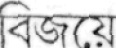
বিজয়ে
